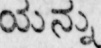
ಯನ್ನು
